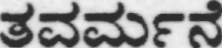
ತವರ್ಮನೆ
